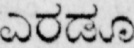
ಎರಡೂ
